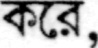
করে,
